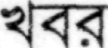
খবর
